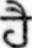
ਹੈ
